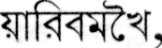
য়ারিবমখৈ,
